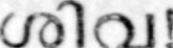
ശിവ!
